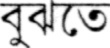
বুঝতে
